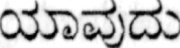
ಯಾವುದು
